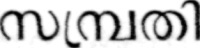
സമ്പ്രതി
